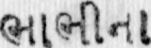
ભાભીના
